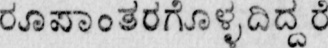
ರೂಪಾಂತರಗೊಳ್ಳದಿದ್ದರೆ
